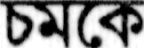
চমকে
